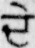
ਦੇ
